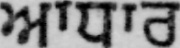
ਆਧਾਰ
